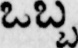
ಒಬ್ಬ
